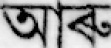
আৰু
